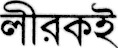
লীরকই
